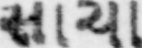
સાચા
